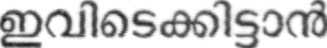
ഇവിടെക്കിട്ടാന്‍
